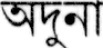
অদুনা
